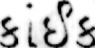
કાંઈક
